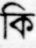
কি
